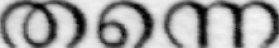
തന്നെ
